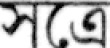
সত্রে
